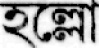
হল্লো
